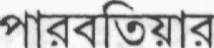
পারবতিয়ার
